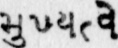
મુખ્યત્વે
